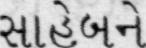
સાહેબને
